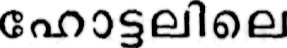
ഹോട്ടലിലെ
